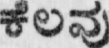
ಕೆಲವು
